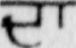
ਦਾ
